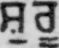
ਸ਼ੁਰੂ
